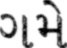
ગમે
